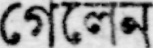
গেলেন
